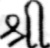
શ્રી
